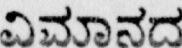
ವಿಮಾನದ
